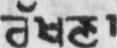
ਰੱਖਣਾ
